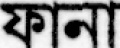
ফানা
